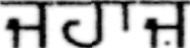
ਜਹਾਜ਼
